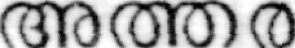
അത്തര
